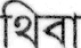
থিবা
